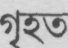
গৃহত
